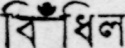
বিঁধিল
